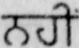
ਨਹੀਂ
